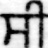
ਸੀ
